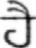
ਹੈ
